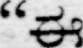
“ಈ
